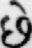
છે
